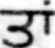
ਤਾਂ
